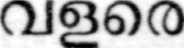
വളരെ
